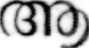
ആ
